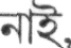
নাই,
